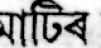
মাটিৰ
